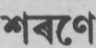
শৰণে
